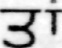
ਤਾਂ
